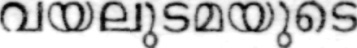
വയലുടമയുടെ
